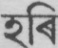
হৰি
